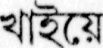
খাইয়ে
